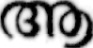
ആ
